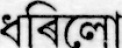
ধৰিলো
